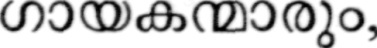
ഗായകന്മാരും,
